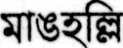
মাঙহল্লি
